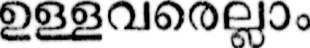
ഉള്ളവരെല്ലാം
